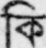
কি
